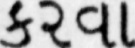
કરવા
